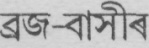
ব্ৰজ-বাসীৰ
